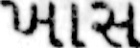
ખાસ
